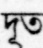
দূত
